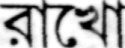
রাখো
